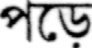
পড়ে
